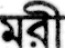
মরী
